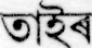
তাইৰ
